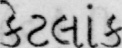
કેટલાંક
